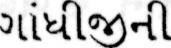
ગાંધીજીની
